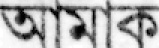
আমাক
